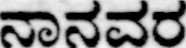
ನಾನವರ
